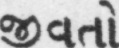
જીવતો
